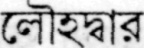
লৌহদ্বার
